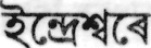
ইন্দ্ৰেশ্বৰে
